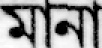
মানা
